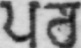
ਪਰ
